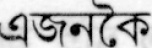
এজনকৈ
